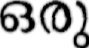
ഒരു
